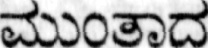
ಮುಂತಾದ
